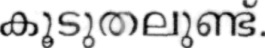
കൂടുതലുണ്ട്.
